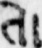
તો
